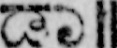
ಡಾ||
